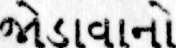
જોડાવાનો
